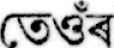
তেওঁৰ
